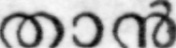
താന്‍
